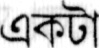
একটা
